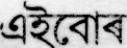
এইবোৰ
